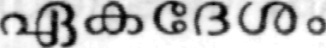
ഏകദേശം
